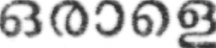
ഒരാളെ
